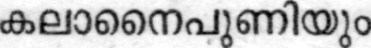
കലാനൈപുണിയും
